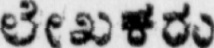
ಲೇಖಕರು
